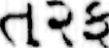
તરફ
